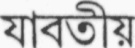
যাবতীয়
